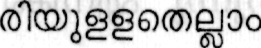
രിയുള്ളതെല്ലാം
